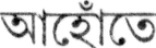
আহোঁতে
